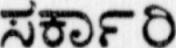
ಸರ್ಕಾರಿ
